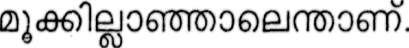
മൂക്കില്ലാഞ്ഞാലെന്താണ്.
